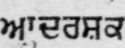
ਆਦਰਸ਼ਕ
